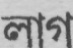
লাগ
